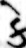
કે
